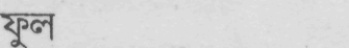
ফুল
